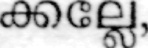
ക്കല്ലേ,
